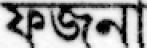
ফজনা
